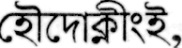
হৌদোক্নীংই,
